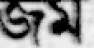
জম
